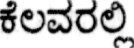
ಕೆಲವರಲ್ಲಿ
